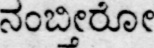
ನ೦ಬ್ತೀರೋ
